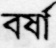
বর্ষা
